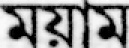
ময়াম
